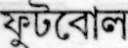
ফুটবোল
